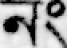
নং
